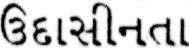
ઉદાસીનતા
